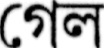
গেল
